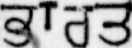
ਭਾਰਤ
